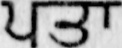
ਪਤਾ
